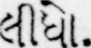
લીધો.
